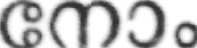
നോം
